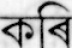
কৰি
